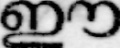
ഈ
